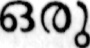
ഒരു
